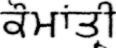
ਕੌਮਾਂਤ੍ਰੀ
